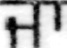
ਜਾ
